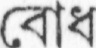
বোধ
